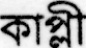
কাপ্লী
